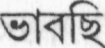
ভাবছি
